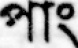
পাং
